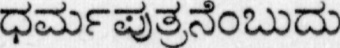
ಧರ್ಮಪುತ್ರನೆಂಬುದು
